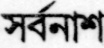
সর্বনাশ
